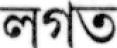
লগত
